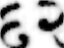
દર
